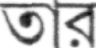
তার
